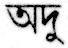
অদু
